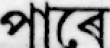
পাৰে
